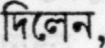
দিলেন,
